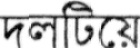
দলটিয়ে
